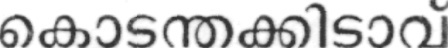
കൊടന്തക്കിടാവ്
